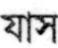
যাস
